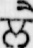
ਲੈ
